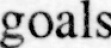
goals
